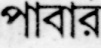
পাবার
